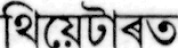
থিয়েটাৰত
